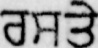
ਰਸਤੇ
